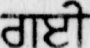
ਗਈ
